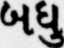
બધુ
